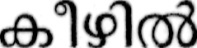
കീഴില്‍
